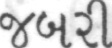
જબરી
